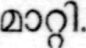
മാറ്റി.
